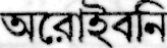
অরোইবনি
